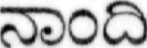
ನಾಂದಿ
